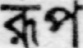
রূপ
